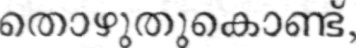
തൊഴുതുകൊണ്ട്,
